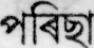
পৰিছা
